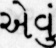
એવું
